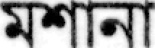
মশানা
